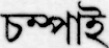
চম্পাই
